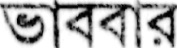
ভাববার
